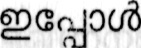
ഇപ്പോള്‍
